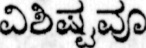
ವಿಶಿಷ್ಟವೂ
